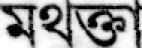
মথক্তা
